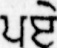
ਪਏ
